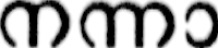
നന്നാ
